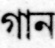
গান
